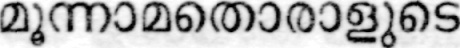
മൂന്നാമതൊരാളുടെ
